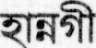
হান্নগী
